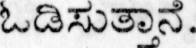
ಓಡಿಸುತ್ತಾನೆ.
